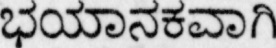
ಭಯಾನಕವಾಗಿ
